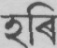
হৰি
